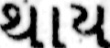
થાય
